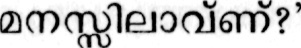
മനസ്സിലാവ്ണ്?’
